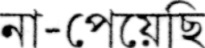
না-পেয়েছি
